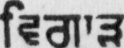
ਵਿਗਾੜ
